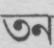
তন
